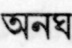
অনঘ
